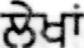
ਲੇਖਾਂ
